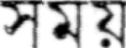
সময়
